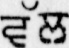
ਵੱਲ
